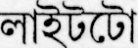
লাইটটো
